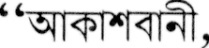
“আকাশবানী,
